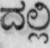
ದಲ್ಲಿ
